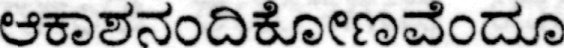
ಆಕಾಶನಂದಿಕೋಣವೆಂದೂ
